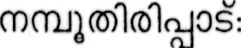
നമ്പൂതിരിപ്പാട്:
